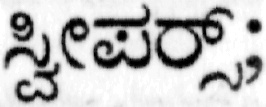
ಸ್ವೀಪರ್‍ಸ್;
